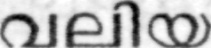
വലിയ
